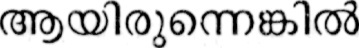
ആയിരുന്നെങ്കില്‍
